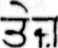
ਤੇਜ਼
